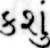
કશું
